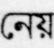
নেয়
